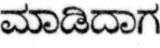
ಮಾಡಿದಾಗ
